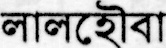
লালহৌবা
